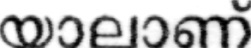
യാലാണ്
